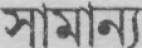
সামান্য
